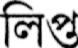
লিপ্ত
